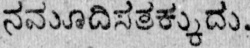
ನಮೂದಿಸತಕ್ಕುದು.
